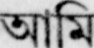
আমি
